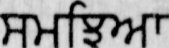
ਸਮਝਿਆ
